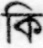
কি
